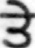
ਤੇ
